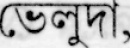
ভেলুদা,
